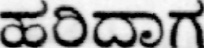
ಹರಿದಾಗ
